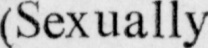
(Sexually
